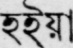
হইয়া
